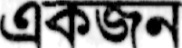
একজন
